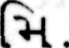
મિ.
